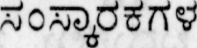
ಸಂಸ್ಕಾರಕಗಳ
